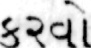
કરવો
